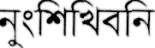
নুংশিখিবনি
